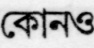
কোনও
